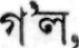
গ'ল,
